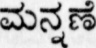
ಮನ್ನಣೆ
